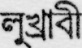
লুখ্রাবী
